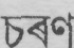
চৰণ
